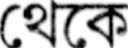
থেকে
